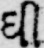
ઘી
